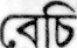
বেচি
